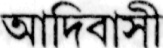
আদিবাসী
